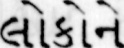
લોકોને
